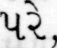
પરે,
